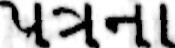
પત્રના
